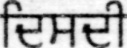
ਦਿਸਦੀ
